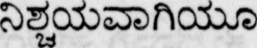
ನಿಶ್ಚಯವಾಗಿಯೂ
